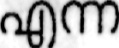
എന്ന
